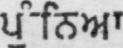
ਪੁੰਨਿਆ
